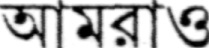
আমরাও
